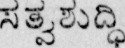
ಸತ್ವಶುದ್ಧಿ
